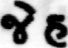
જેહ
